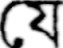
যে
